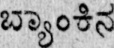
ಬ್ಯಾಂಕಿನ
